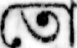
তো
